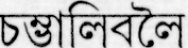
চম্ভালিবলৈ
